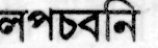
লেপচবনি
